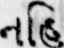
નહિ
